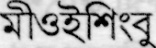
মীওইশিংবু
